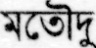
মতৌদু
